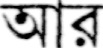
আর
